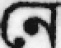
নে
